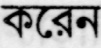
করেন
